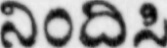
ನಿಂದಿಸಿ
